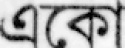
একো
